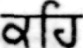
ਕਹਿ
